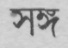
সঙ্গ
